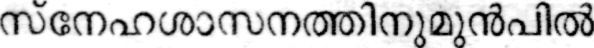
സ്നേഹശാസനത്തിനുമുന്‍പില്‍
